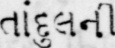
તાંદુલની
